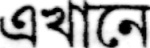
এখানে
